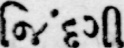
જિંદગી
